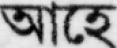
আহে
